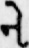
ને
